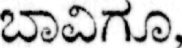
ಬಾವಿಗೂ,
